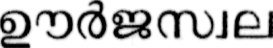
ഊര്‍ജസ്വല
